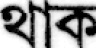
থাক
